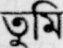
তুমি
